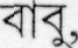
বাবু,
